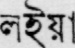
লইয়া
